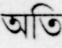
অতি
